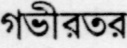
গভীরতর
